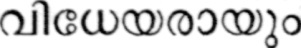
വിധേയരായും
